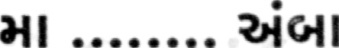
મા.....અંબા
